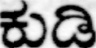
ಕುಡಿ
